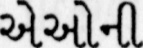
એઓની
